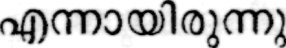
എന്നായിരുന്നു
